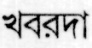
খবরদা
